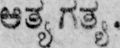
ಅತ್ಯಗತ್ಯ.
